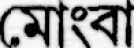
মোংবা
